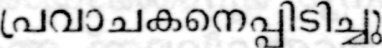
പ്രവാചകനെപ്പിടിച്ചു
